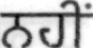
ਨਹੀਂ
